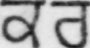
ਕਰ
